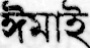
ঈমাই
